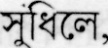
সুধিলে,
